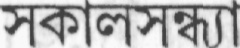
সকালসন্ধ্যা
